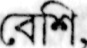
বেশি,
